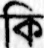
কি
